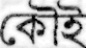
কৌই
